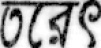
তরেৎ
